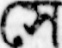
সে
